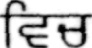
ਵਿਚ
